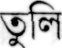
তুলি
